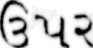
ઉપર
